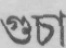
গুচা
